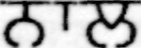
ਨਾਲ
